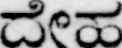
ದೇಹ
